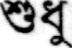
শুধু
